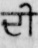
ਦੀ
